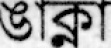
ঙাক্না
